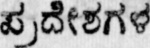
ಪ್ರದೇಶಗಳ
